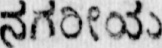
ನಗರೀಯ
